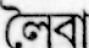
লৈবা
